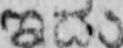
ಇದು
